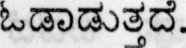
ಓಡಾಡುತ್ತದೆ.
